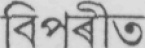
বিপৰীত
